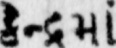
કેન્દ્રમાં
